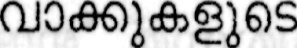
വാക്കുകളുടെ
